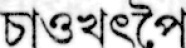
চাওখৎপৈ
